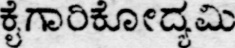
ಕೈಗಾರಿಕೋದ್ಯಮಿ
